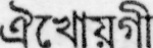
ঐখোয়গী
